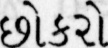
છોકરો
